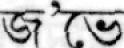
জ'ভে
